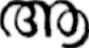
ആ
